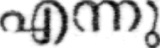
എന്നു
